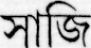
সাজি
